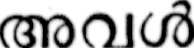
അവള്‍
